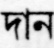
দান
